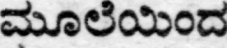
ಮೂಲೆಯಿಂದ
